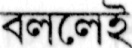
বললেই
